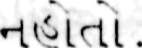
નહોતો.
